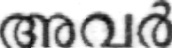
അവര്‍
